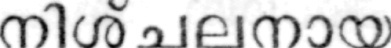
നിശ്ചലനായ
